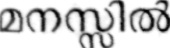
മനസ്സില്‍
